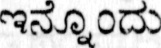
ಇನ್ನೊಂದು
